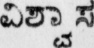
ವಿಶ್ವಾಸ
